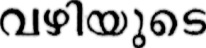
വഴിയുടെ
